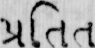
પ્રતિત
